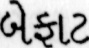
બેફાટ
